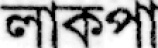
লাকপা
